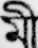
মী
